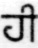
ਹੀ
